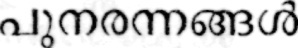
പുനരന്നങ്ങള്‍
